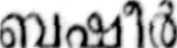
ബഷീര്‍
